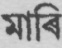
মাৰি
